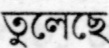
তুলেছে
